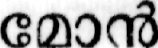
മോന്‍
